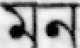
মন
